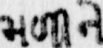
મળીને
